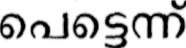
പെട്ടെന്ന്
